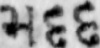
મદદ
